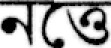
নত্তে
